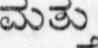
ಮತ್ತು
